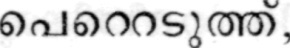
പെറെറടുത്ത്,
